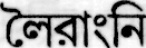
লৈরাংনি
